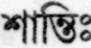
শান্তিঃ
